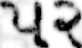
પર
